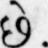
છે.
